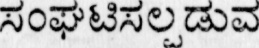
ಸಂಘಟಿಸಲ್ಪಡುವ
